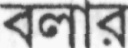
বলার
